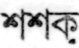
শশক
